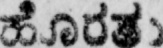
ಹೊರತು
